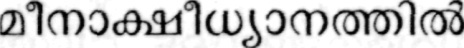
മീനാക്ഷീധ്യാനത്തില്‍
